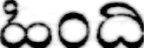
ಹಿಂದಿ
